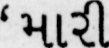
'મારી
